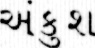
અંકુશ
